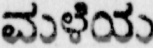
ಮಳೆಯ
